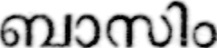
ബാസിം
